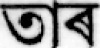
তাৰ
